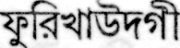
ফুরিখাউদগী
